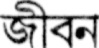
জীবন
